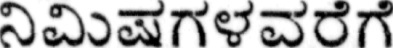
ನಿಮಿಷಗಳವರೆಗೆ
